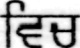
ਵਿਚ
